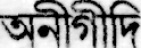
অনীগীদি
